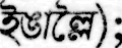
ইঙাল্লৈ);
